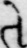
તે
